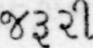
જરૂરી
